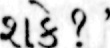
શકે?'
